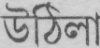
উঠিলা
